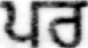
ਪਰ
